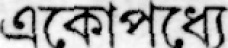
একোপধ্যে
